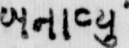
બનાવ્યું
